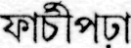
ফাচীপঢ়া
